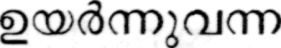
ഉയര്‍ന്നുവന്ന
